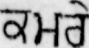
ਕਮਰੇ
